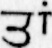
ਤਾਂ
